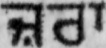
ਜ਼ਰਾ
